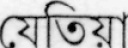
যেতিয়া
